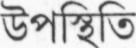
উপস্থিতি
